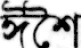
ঈশৈ
